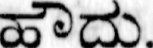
ಹೌದು.
